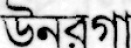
উনরগা
